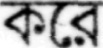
করে
